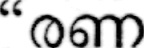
“രണ
